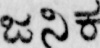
ಜನಿಕ
